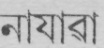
নাযাৱা
